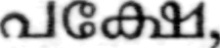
പക്ഷേ,
